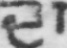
ਦਾ
